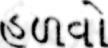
હળવો
